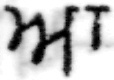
ਆ
